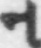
ન
